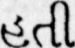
હતી
